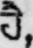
ਹੈ,
